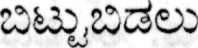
ಬಿಟ್ಟುಬಿಡಲು
